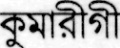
কুমারীগী
